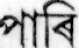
পাৰি
